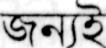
জন্যই
